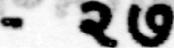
-ર૭
